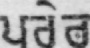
ਪਰੇਰ
